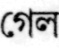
গেল
